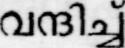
വന്ദിച്ച്
